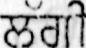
ਲੱਗੀ
